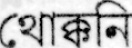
থোক্কনি
